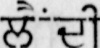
ਲੈਂਦੀ
